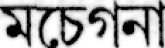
মচেগনা
